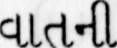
વાતની
